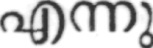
എന്നു
